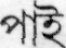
পাই
